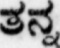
ತನ್ನ
